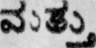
ಮತ್ತು
